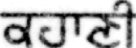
ਕਹਾਣੀ
